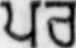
ਪਰ
